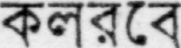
কলরবে
